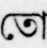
তো
